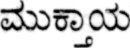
ಮುಕ್ತಾಯ
